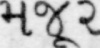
મજૂર
